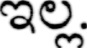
ಇಲ್ಲ.
